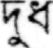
দুধ
